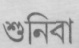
শুনিবা
